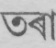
তৰা
